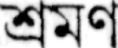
শ্রমণ
